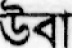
উবা
